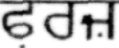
ਫ਼ਰਜ਼
